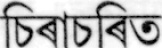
চিৰাচৰিত
